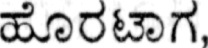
ಹೊರಟಾಗ,
